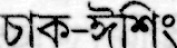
চাক-ঈশিং
